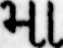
મા
